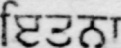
ਇਤਨਾ
